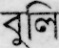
বুলি
